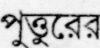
পুত্তুরের
